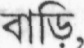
বাড়ি,
